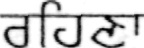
ਰਹਿਣਾ
